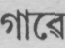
গাৱে
